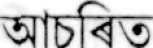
আচৰিত
